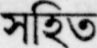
সহিত
